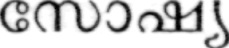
സോഷ്യ
